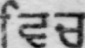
ਵਿਚ
